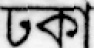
ঢকা
